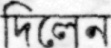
দিলেন
